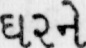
ઘરને
